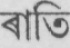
ৰাতি
